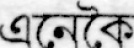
এনেকৈ
